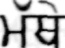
ਮੱਥੇ
